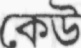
কেউ
